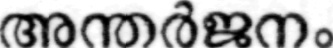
അന്തര്‍ജനം
